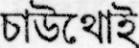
চাউথোই
